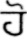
ਹੋ
